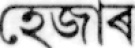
হেজাৰ
